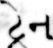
ટ્રેન
